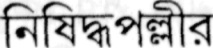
নিষিদ্ধপল্লীর
